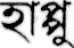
হাপ্পু
